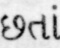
છતાં
